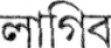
লাগিব
